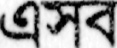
এসব
